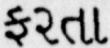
ફરતા
